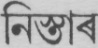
নিস্তাৰ
